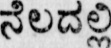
ನೆಲದಲ್ಲಿ
